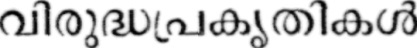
വിരുദ്ധപ്രകൃതികള്‍
